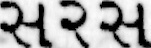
સરસ
